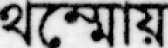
থম্মোয়
